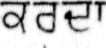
ਕਰਦਾ
